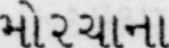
મોરચાના
